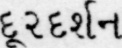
દૂરદર્શન
